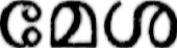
മേശ
